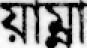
য়াম্না
